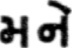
મને
